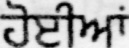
ਹੋਈਆਂ
